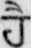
ਹੈ
